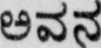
ಅವನ
